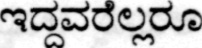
ಇದ್ದವರೆಲ್ಲರೂ
